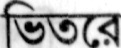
ভিতরে
